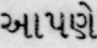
આપણે
